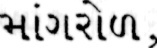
માંગરોળ,
